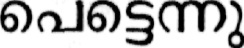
പെട്ടെന്നു
